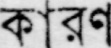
কারণ
